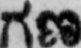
ಗಣ
